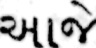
આજે
